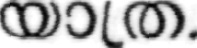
യാത്ര.
